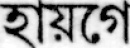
হায়গে
